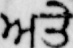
ਅਤੇ
